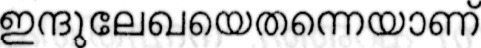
ഇന്ദുലേഖയെതന്നെയാണ്
